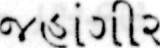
જહાંગીર
